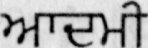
ਆਦਮੀ
